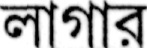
লাগার
